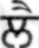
ਲੈ
